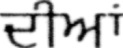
ਦੀਆਂ
